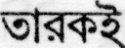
তারকই
